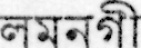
লমনগী
